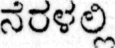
ನೆರಳಲ್ಲಿ
